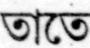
তাতে
